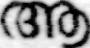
ആ
